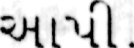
આપી.
